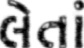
લેતાં
